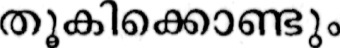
തൂകിക്കൊണ്ടും
